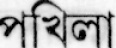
পখিলা
